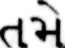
તમે
